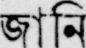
জানি
